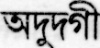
অদুদগী
